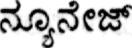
ನ್ಯೂನೇಜ್
